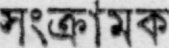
সংক্রামক
